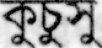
কুচুসু
